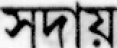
সদায়
